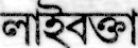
লাইবক্তা
